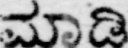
ಮಾಡಿ
